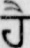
ਹੈ
